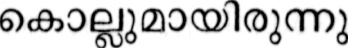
കൊല്ലുമായിരുന്നു
